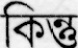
কিন্তু
